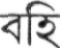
বহি
